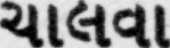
ચાલવા
